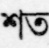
শত
